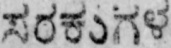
ಸರಕುಗಳ
